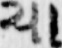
ચા
